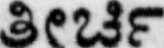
ತೀರ್ಚಿ
